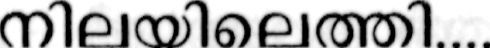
നിലയിലെത്തി....
